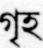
গৃহ
